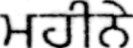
ਮਹੀਨੇ
